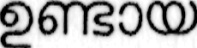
ഉണ്ടായ
